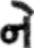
ને
